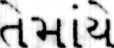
તેમાંયે
